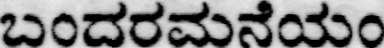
ಬಂದರಮನೆಯಂ
